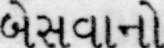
બેસવાનો
